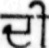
ਦੀ
